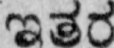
ಇತರ
